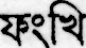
ফংখি
